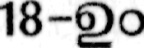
18-ഉം
